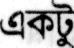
একটু
